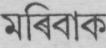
মৰিবাক
